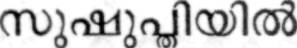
സുഷുപ്തിയില്‍
